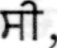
ਸੀ,
